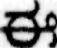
ಈ
